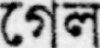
গেল
